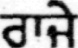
ਰਾਜੇ
